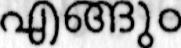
എങ്ങും
